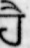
ਹੈ
